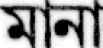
মানা
